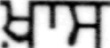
ਖ਼ਾਸ
